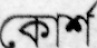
কোর্শ
